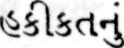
હકીકતનું
